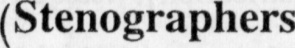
(Stenographers
